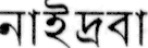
নাইদ্রবা
